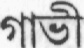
গাভী
